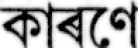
কাৰণে
